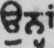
ਉਨ੍ਹਾਂ
